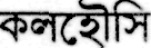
কলহৌসি
